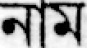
নাম
